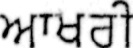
ਆਖਰੀ
